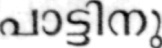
പാട്ടിനു
